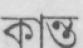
কান্ত
